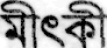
মীৎকী
